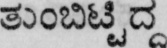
ತುಂಬಿಟ್ಟಿದ್ದ
